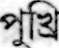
পুখ্রি
